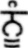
ਨੂੰ
